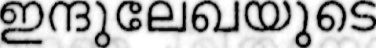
ഇന്ദുലേഖയുടെ
